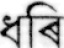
ধৰি
